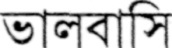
ভালবাসি
